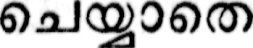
ചെയ്യാതെ
